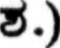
ಶ.)
